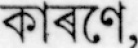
কাৰণে,
